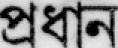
প্রধান
